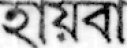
হায়বা
